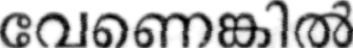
വേണെങ്കില്‍
